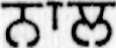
ਨਾਲ
